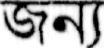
জন্য
